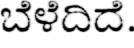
ಬೆಳೆದಿದೆ.
